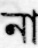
না
